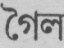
গৈল
